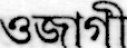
ওজাগী
